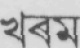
খৰম
